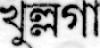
খুল্লগা
